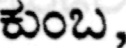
ಕುಂಬ,
